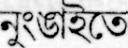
নুংঙাইতে
